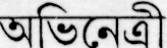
অভিনেত্রী
